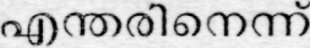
എന്തരിനെന്ന്
